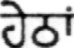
ਹੇਠਾਂ
